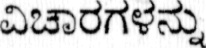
ವಿಚಾರಗಳನ್ನು
